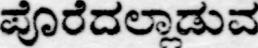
ಪೊರೆದಲ್ಲಾಡುವ
